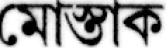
মোস্তাক
